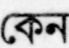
কেন
